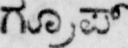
ಗ್ರೂಪ್
